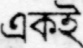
একই
